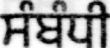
ਸੰਬੰਧੀ
